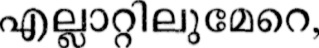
എല്ലാറ്റിലുമേറെ,
